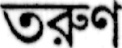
তরুণ
